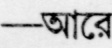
–আরে
